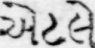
એટલે
